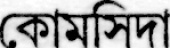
কোমসিদা
